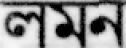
লমন
